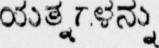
ಯತ್ನಗಳನ್ನು
